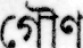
গৌণ
